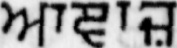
ਆਵਾਜ਼
